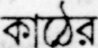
কাঠের
